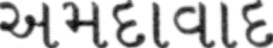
અમદાવાદ
